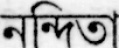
নন্দিতা
